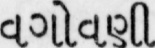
વગોવણી
